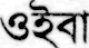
ওইবা
